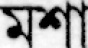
মশা
